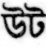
উট
